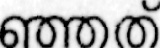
ഞ്ഞത്
